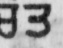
ਚਤ
